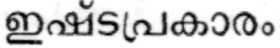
ഇഷ്ടപ്രകാരം
